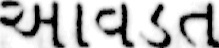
આવડત
